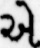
એ
